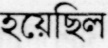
হয়েছিল
